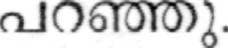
പറഞ്ഞു.
